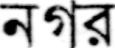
নগর
